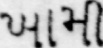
ખામી
